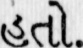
હતો.
